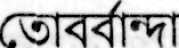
তোর্ব্বান্দা
